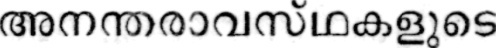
അനന്തരാവസ്ഥകളുടെ
